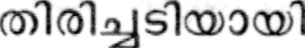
തിരിച്ചടിയായി
